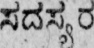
ಸದಸ್ಯರ
